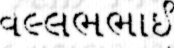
વલ્લભભાઈ
